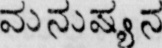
ಮನುಷ್ಯನ
